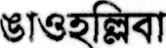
ঙাওহল্লিবা
